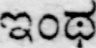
ಇಂಥ
